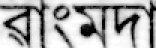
ৱাংমদা
